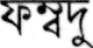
ফম্বদু
